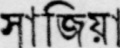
সাজিয়া
